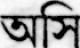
অসি
